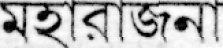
মহারাজনা
